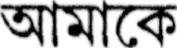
আমাকে
